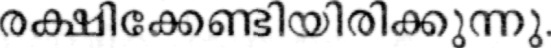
രക്ഷിക്കേണ്ടിയിരിക്കുന്നു.
